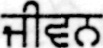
ਜੀਵਨ
